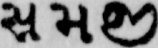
સમજી
